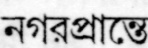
নগরপ্রান্তে
